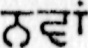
ਨਵਾਂ
